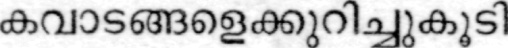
കവാടങ്ങളെക്കുറിച്ചുകൂടി
